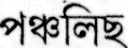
পঞ্চলিছ
